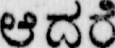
ಆದರೆ
